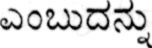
ಎಂಬುದನ್ನು
